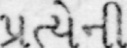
પ્રત્યેની
